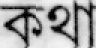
কথা
